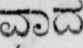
ವಾದ
